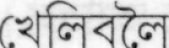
খেলিবলৈ
